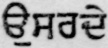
ਉਸਰਦੇ
